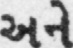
અને
